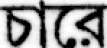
চারে
